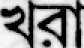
খরা
